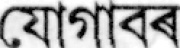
যোগাবৰ
